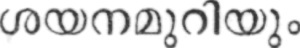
ശയനമുറിയും
